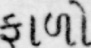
ફાળો
